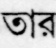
তার
